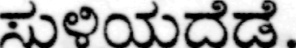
ಸುಳಿಯದೆಡೆ,
